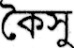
কৈসু
